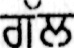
ਗੱਲ
